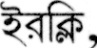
ইরক্লি,
